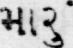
મારું
